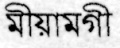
মীয়ামগী
